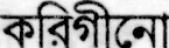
করিগীনো
